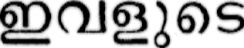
ഇവളുടെ
